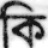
কি
